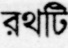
রথটি
